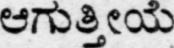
ಆಗುತ್ತೀಯೆ
